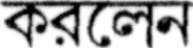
করলেন
